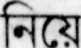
নিয়ে
